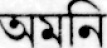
অমনি
